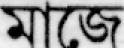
মাজে
